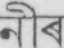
নীৰ
